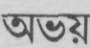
অভয়
